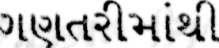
ગણતરીમાંથી
